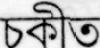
চকীত
